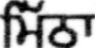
ਮਿੱਠਾ
